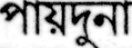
পায়দুনা
